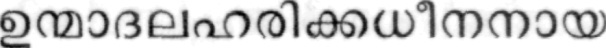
ഉന്മാദലഹരിക്കധീനനായ
